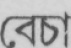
বেচা
